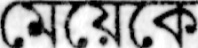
মেয়েকে
